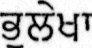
ਭੁਲੇਖਾ
